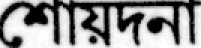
শোয়দনা
